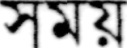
সময়
